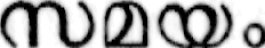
സമയം
